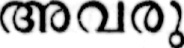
അവരു
